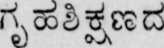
ಗೃಹಶಿಕ್ಷಣದ
